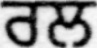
ਰਲ
